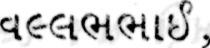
વલ્લભભાઈ,
